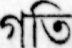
গতি
